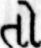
તો
